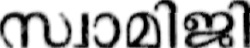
സ്വാമിജി
